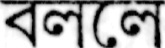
বললে
